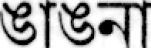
ঙাঙনা
